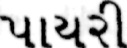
પાયરી
